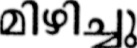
മിഴിച്ചു
